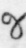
જ
